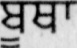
ਬੂਥਾ
